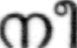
നീ
